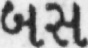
બસ
